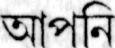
আপনি
